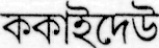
ককাইদেউ
